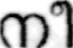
നീ
